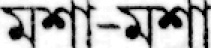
মশা-মশা
